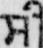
ਸੀ
